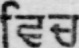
ਵਿਚ
